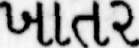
ખાતર
